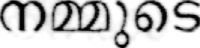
നമ്മുടെ
